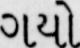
ગયો
